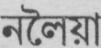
নলৈয়া
